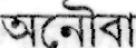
অনৌবা
